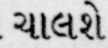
ચાલશે
